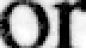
or
